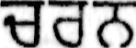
ਚਰਨ
